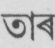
তাৰ
